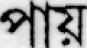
পায়
